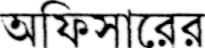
অফিসারের
